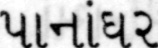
પાનાંઘર
